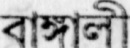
বাঙ্গালী
